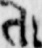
તો
